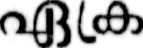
ഏക്ര
